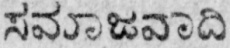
ಸಮಾಜವಾದಿ
